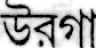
উরগা
